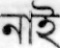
নাই
